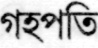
গহপতি
